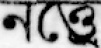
নত্ত্রে
